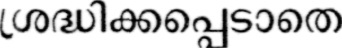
ശ്രദ്ധിക്കപ്പെടാതെ
